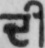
ਦੀ
